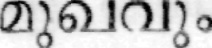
മുഖവും
